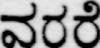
ವರರೆ
